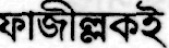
ফাজীল্লকই
